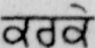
ਕਰਕੇ
